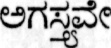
ಅಗಸ್ತ್ಯವೇ
